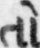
તો
